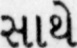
સાથે
